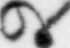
જ
